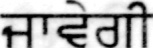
ਜਾਵੇਗੀ
